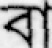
বা
